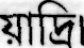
য়াদ্রি।
